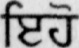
ਇਹੋ
